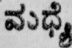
ಮಧ್ಯೆ
